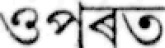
ওপৰত
